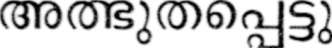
അത്ഭുതപ്പെട്ടു
